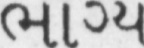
ભાગ્ય
